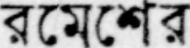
রমেশের
